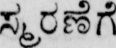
ಸ್ಮರಣೆಗೆ
